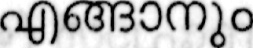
എങ്ങാനും
